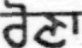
ਰੋਣਾ
